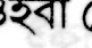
ওহবা
